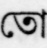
তো
